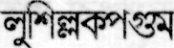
লুশিল্লকপগুম
